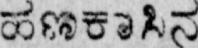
ಹಣಕಾಸಿನ
